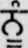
ਨੂੰ
